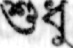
শুধু
